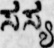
ಸಸ್ಯ
